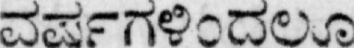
ವರ್ಷಗಳಿಂದಲೂ
